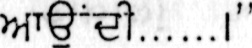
ਆਉਂਦੀ...........।''
